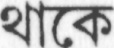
থাকে
